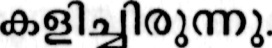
കളിച്ചിരുന്നു.
